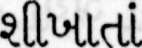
શીખાતાં
